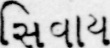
સિવાય
